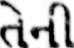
તેની
